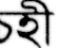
চহী
